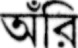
অঁরি
